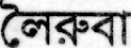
লৈরুবা
